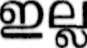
ഇല്ല
